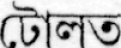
টোলত
